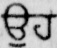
ਉਹ
